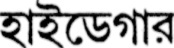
হাইডেগার
